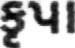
કૃપા
